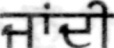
ਜਾਂਦੀ
